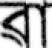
ৱা
